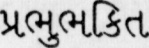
પ્રભુભક્તિ
